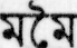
মমৈ
